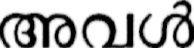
അവള്‍
